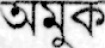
অমুক
